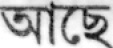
আছে
